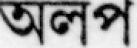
অলপ
